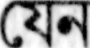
যেন
